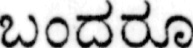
ಬಂದರೂ
